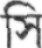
সি
